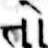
તો
